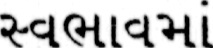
સ્વભાવમાં
